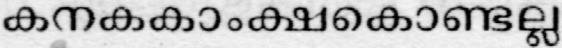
കനകകാംക്ഷകൊണ്ടല്ല
